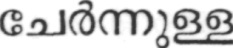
ചേര്‍ന്നുള്ള
